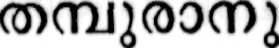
തമ്പുരാനു
